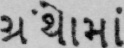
ગ્રંથોમાં
